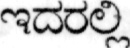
ಇದರಲ್ಲಿ
